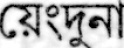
য়েংদুনা
